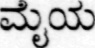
ಮೈಯ
